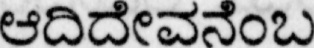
ಆದಿದೇವನೆಂಬ
